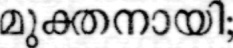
മുക്തനായി;
